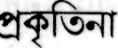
প্রকৃতিনা
